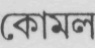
কোমল
